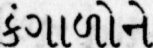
કંગાળોને
